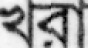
খরা
